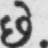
છે.
